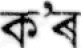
ক'ৰ
